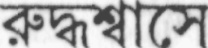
রুদ্ধশ্বাসে
